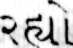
રહ્યો
